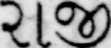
રાજી
